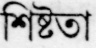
শিষ্টতা
